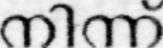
നിന്ന്
